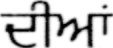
ਦੀਆਂ
